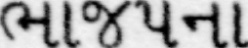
ભાજપના
